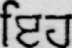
ਇਹ
